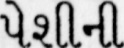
પેશીની
